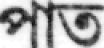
পাত
